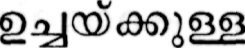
ഉച്ചയ്ക്കുള്ള
